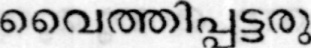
വൈത്തിപ്പട്ടരു
